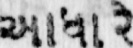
આધારે
